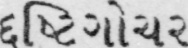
દ્દષ્ટિગોચર
